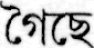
গৈছে
